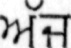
ਅੱਜ
